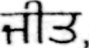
ਜੀਤ,
